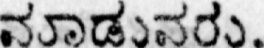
ಮಾಡುವರು.
